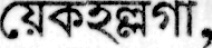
য়েকহল্লগা,
